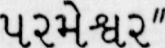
પરમેશ્વર"
